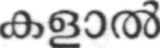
കളാല്‍
